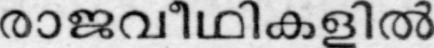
രാജവീഥികളില്‍
